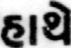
હાથે
